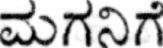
ಮಗನಿಗೆ
